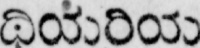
ಥಿಯೆರಿಯ
